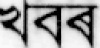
খবৰ
